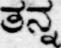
ತನ್ನ
